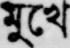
মুখে
